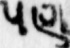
પણ
